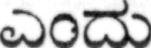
ಎಂದು
